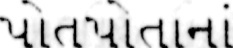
પોતપોતાનાં
